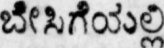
ಬೇಸಿಗೆಯಲ್ಲಿ
